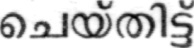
ചെയ്തിട്ട്
